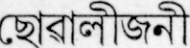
ছোৱালীজনী
